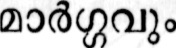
മാര്‍ഗ്ഗവും
